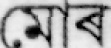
মোৰ
